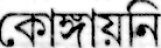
কোঙ্গায়নি
